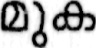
മുക
